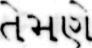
તેમણે
